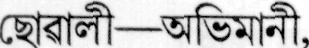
ছোৱালী-অভিমানী,
